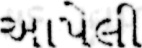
આપેલી
